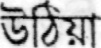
উঠিয়া
